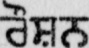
ਰੌਸ਼ਨ
